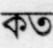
কত
